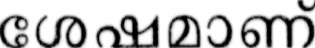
ശേഷമാണ്
